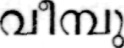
വീമ്പു
